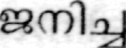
ജനിച്ച
